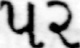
પર
